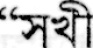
“সখী
